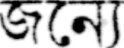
জন্যে
